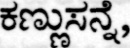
ಕಣ್ಣುಸನ್ನೆ,
